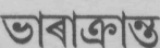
ভাৰাক্ৰান্ত
